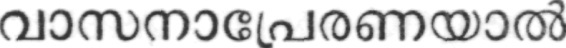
വാസനാപ്രേരണയാല്‍
